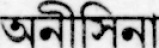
অনীসিনা
